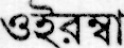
ওইরম্বা
